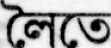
লৈতে
